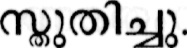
സ്തുതിച്ചു.
